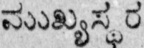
ಮುಖ್ಯಸ್ಥರ
